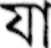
যা
